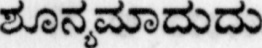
ಶೂನ್ಯಮಾದುದು
